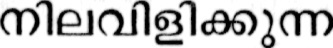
നിലവിളിക്കുന്ന
